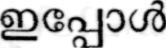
ഇപ്പോള്‍
